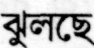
ঝুলছে
